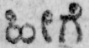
ಹೀಗೆ
